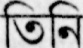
তিনি
